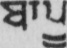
ਬਾਪੂ
